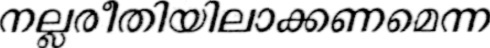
നല്ലരീതിയിലാക്കണമെന്ന
